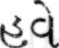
હવે
